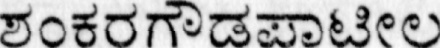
ಶಂಕರಗೌಡಪಾಟೀಲ
